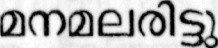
മനമലരിട്ടു
